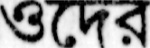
ওদের
